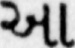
આ
